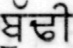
ਬੁੱਢੀ
